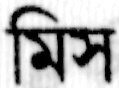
মিস
